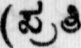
(ಪ್ರತಿ
